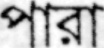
পারা
